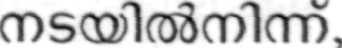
നടയില്‍നിന്ന്,
